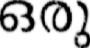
ഒരു
